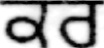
ਕਰ
